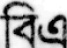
বিএ
